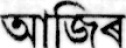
আজিৰ
